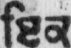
ਇਕ
